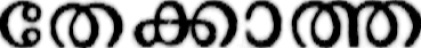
തേക്കാത്ത
